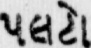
પલટો
